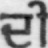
ਦੀ
